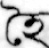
হৈ
